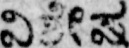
ವಿಶೇಷ
